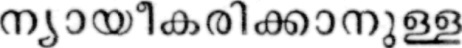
ന്യായീകരിക്കാനുള്ള
